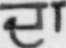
ਦਾ
